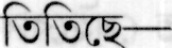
তিতিছে-
